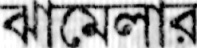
ঝামেলার
